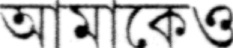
আমাকেও
